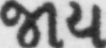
જાય
